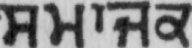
ਸਮਾਜਕ
